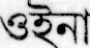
ওইনা
